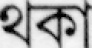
থকা
